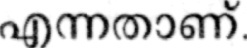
എന്നതാണ്.
